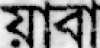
য়াবা
